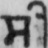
ਸੀ
